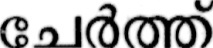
ചേര്‍ത്ത്
